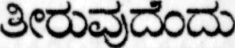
ತೀರುವುದೆಂದು
